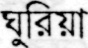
ঘুরিয়া
